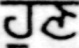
ਹੁਣ
